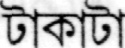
টাকাটা
